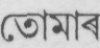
তোমাৰ
